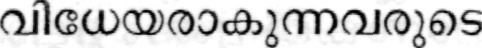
വിധേയരാകുന്നവരുടെ
